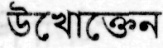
উখোক্তেন
